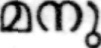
മനു
